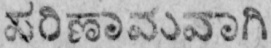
ಪರಿಣಾಮವಾಗಿ
